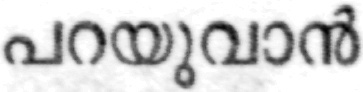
പറയുവാന്‍
